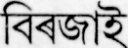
বিৰজাই
